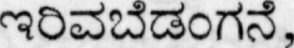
ಇರಿವಬೆಡಂಗನೆ,
